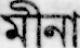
মীনা
